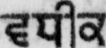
ਵਧੀਕ
